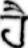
ਹੈ
